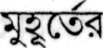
মুহূর্তের
